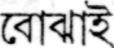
বোঝাই
